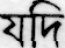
যদি
